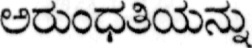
ಅರುಂಧತಿಯನ್ನು
